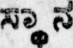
ಸ್ಥಾನ
